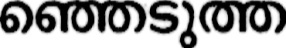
ഞ്ഞെടുത്ത
